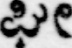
ಘೀ
